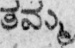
ತಮ್ಮ
